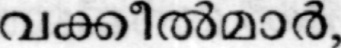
വക്കീല്‍മാര്‍,
